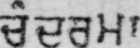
ਚੰਦਰਮਾ
